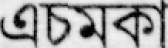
এচমকা
